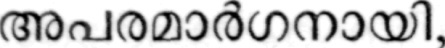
അപരമാര്‍ഗനായി,
